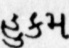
હુકમ
